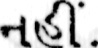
નહીં.
